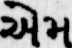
એમ
